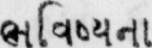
ભવિષ્યના
